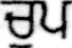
ਚੁਪ
